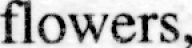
flowers,
